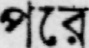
পরে
